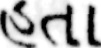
હતા
